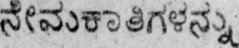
ನೇಮಕಾತಿಗಳನ್ನು
